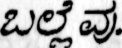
ಬಲ್ಲೆವು.
